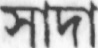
সাদা
